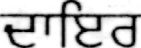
ਦਾਇਰ
